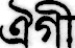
ঐগী
